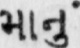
માનું
